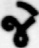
જે
